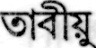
তাবীয়ু
